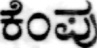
ಕೆಂಪು
